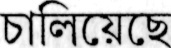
চালিয়েছে
